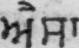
ਐਸਾ
